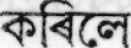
কৰিলে
